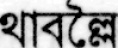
থাবল্লৈ
